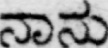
ನಾನು
